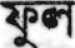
ফুল
